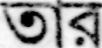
তার
